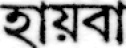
হায়বা
